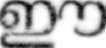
ഈ
